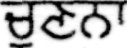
ਚੁਣਨਾਂ
